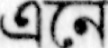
এনে
